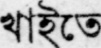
খাইতে
